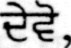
ਦੇਵੋ,
